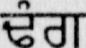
ਢੰਗ
